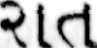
રાત
